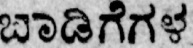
ಬಾಡಿಗೆಗಳ
